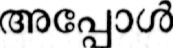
അപ്പോള്‍
